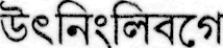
উৎনিংলিবগে
